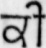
ਕੀ
